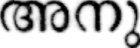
അനു
